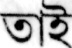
তাই
